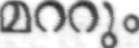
മററും
